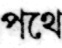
পথে
